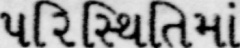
પરિસ્થિતિમાં
